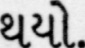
થયો.
